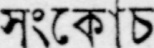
সংকোচ
